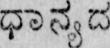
ಧಾನ್ಯದ
